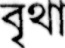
বৃথা
